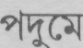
পদুমে
